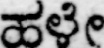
ಹಳೇ
